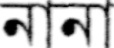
নানা
